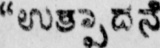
“ಉತ್ಪಾದನೆ
